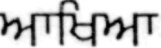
ਆਖਿਆ
